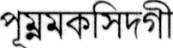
পূম্নমকসুদগী
